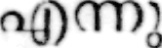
എന്നു
